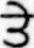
ਤੇ
